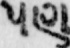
પણ
